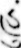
હું
